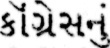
કૉંગ્રેસનું
